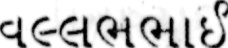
વલ્લભભાઈ
